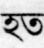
হত
